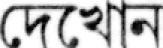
দেখোন
